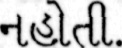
નહોતી.
